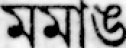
মমাঙ
